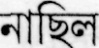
নাছিল
